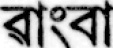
ৱাংবা
